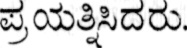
ಪ್ರಯತ್ನಿಸಿದರು.
